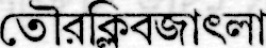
তৌরক্লিবজাৎলা
